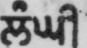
ਲੰਘੀ
